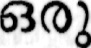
ഒരു
